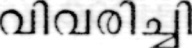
വിവരിച്ചി
